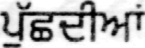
ਪੁੱਛਦੀਆਂ
